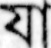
যা
